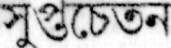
সুপ্তচেতন
